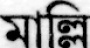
মাল্লি
